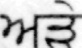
ਅੜੇ
